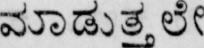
ಮಾಡುತ್ತಲೇ
